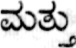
ಮತ್ತು
